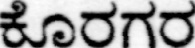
ಕೊರಗರ
